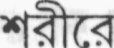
শরীরে
